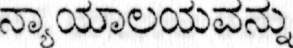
ನ್ಯಾಯಾಲಯವನ್ನು
